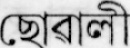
ছোৱালী
